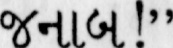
જનાબ!"
